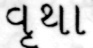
વૃથા
